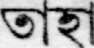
তাহা
